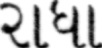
રાધા
